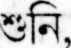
শুনি,
